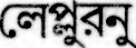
লেপ্লুরনু
